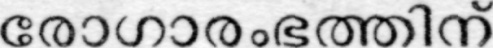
രോഗാരംഭത്തിന്
